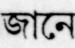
জানে
